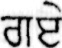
ਗਏ
